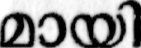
മായി
